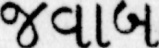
જવાબ
